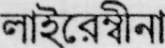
লাইরেম্বীনা
